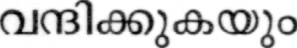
വന്ദിക്കുകയും
